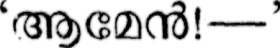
‘ആമേന്‍!-’
